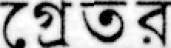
গ্রেতর
